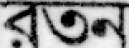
রতন
